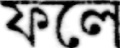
ফলে
